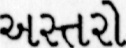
અસ્તરો
